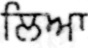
ਲਿਆ
